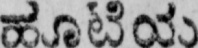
ಹೂಟೆಯ
